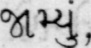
જામ્યું,
